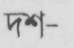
দশ-
